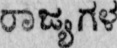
ರಾಜ್ಯಗಳ
